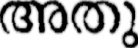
അതു
